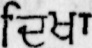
ਦਿਖਾ
